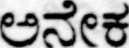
ಅನೇಕ
